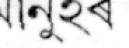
মানুহৰ
